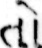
તો
